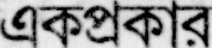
একপ্রকার
